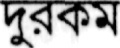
দুরকম
